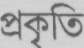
প্ৰকৃতি
